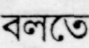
বলতে
